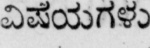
ವಿಷಯಗಳು
